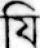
যি
